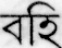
বহি
